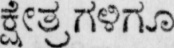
ಕ್ಷೇತ್ರಗಳಿಗೂ
